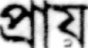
প্রায়
